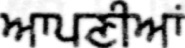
ਆਪਣੀਆਂ
